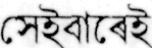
সেইবাৰেই
